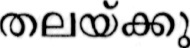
തലയ്ക്കു
